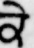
ਕੇ
